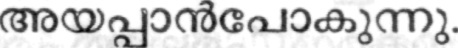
അയപ്പാന്‍പോകുന്നു.
